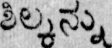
ಶಿಲ್ಕನ್ನು
